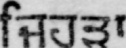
ਜਿਹੜਾ
